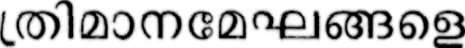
ത്രിമാനമേഘങ്ങളെ
